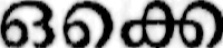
ഒക്കെ
